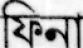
ফিনা
